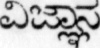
ವಿಜ್ಞಾನ
